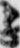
કે
